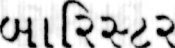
બારિસ્ટર
